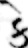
કે
